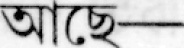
আছে-
